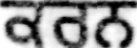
ਕਰਨ
